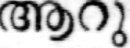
ആറു
